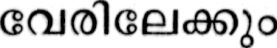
വേരിലേക്കും
